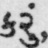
કરું,
